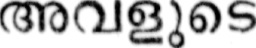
അവളുടെ
